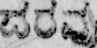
ದರವು
